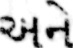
અને
